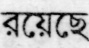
রয়েছে
